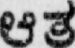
ಆತ
